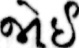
જોઈ
